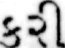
કરી
